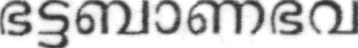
ഭട്ടബാണഭവ
